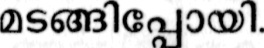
മടങ്ങിപ്പോയി.
